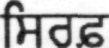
ਸਿਰਫ਼
